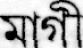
মাগী
